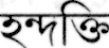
হন্দক্তি
